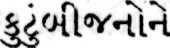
કુટુંબીજનોને
